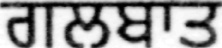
ਗਲਬਾਤ
